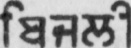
ਬਿਜਲੀ
